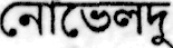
নোভেলসু
